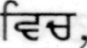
ਵਿਚ,
